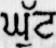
ਘੁੱਟ
